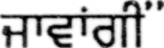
ਜਾਵਾਂਗੀ''
